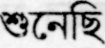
শুনেছি
